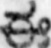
ಈ
